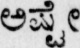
ಅಷ್ಟೇ
